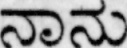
ನಾನು
